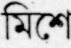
মিশে
